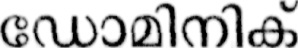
ഡോമിനിക്
